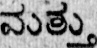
ಮತ್ತು
